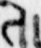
તો
